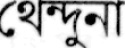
থেন্দুনা
